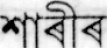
শাৰীৰ
